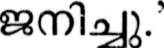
ജനിച്ചു.'
